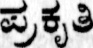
ಪ್ರಕೃತಿ
